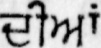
ਦੀਆਂ
